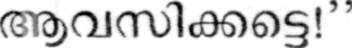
ആവസിക്കട്ടെ!"
